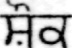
ਸ਼ੌਕ
